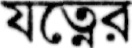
যত্নের
